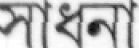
সাধনা
